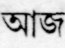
আজ
